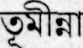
তূমীন্না
